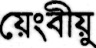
য়েংবীয়ু
